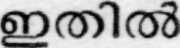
ഇതില്‍
